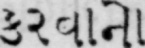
કરવાનો
